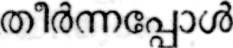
തീര്‍ന്നപ്പോള്‍
